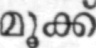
മൂക്ക്
